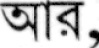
আর,
